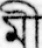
মী
